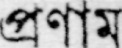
প্রণাম
